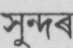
সুন্দৰ
